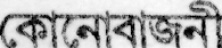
কোনোবাজনী
